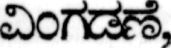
ವಿಂಗಡಣೆ,
